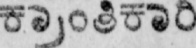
ಕ್ರಾಂತಿಕಾರಿ
